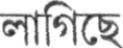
লাগিছে
